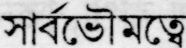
সার্বভৌমত্বে
